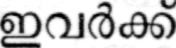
ഇവര്‍ക്ക്
